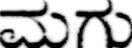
ಮಗು
